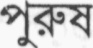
পুরুষ
